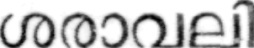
ശരാവലി
